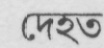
দেহত
